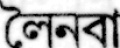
লৈনবা
